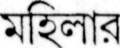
মহিলার
